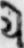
યે
